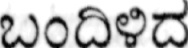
ಬಂದಿಳಿದ
